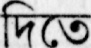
দিতে
